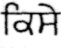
ਕਿਸੇ
